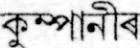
কুম্পানীৰ
